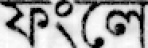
ফংলে
